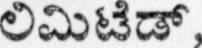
ಲಿಮಿಟೆಡ್,
